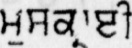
ਮੁਸਕ੍ਰਾਈ
